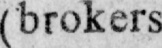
(brokers
